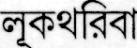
লূকথরিবা
